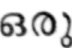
ഒരു
